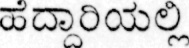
ಹೆದ್ದಾರಿಯಲ್ಲಿ
